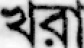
খরা
